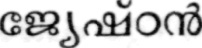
ജ്യേഷ്ഠന്‍
